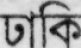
ঢাকি
